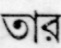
তার
